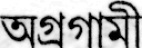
অগ্ৰগামী
